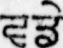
ਵਡੇ
